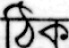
ঠিক
